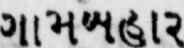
ગામબહાર
